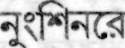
নুংশিনরে
